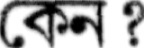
কেন?
